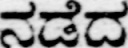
ನಡೆದ
